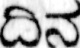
ದಿನ
